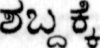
ಶಬ್ದಕ್ಕೆ
